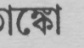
চাঙ্কো
